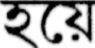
হয়ে
